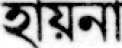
হায়না
